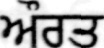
ਔਰਤ
